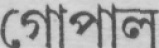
গোপাল
